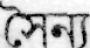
সৈন্য
